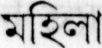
মহিলা
